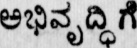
ಅಭಿವೃದ್ಧಿಗೆ
